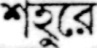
শহুরে
